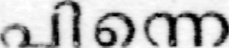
പിന്നെ
